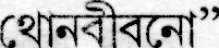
থোনবীবনো”
